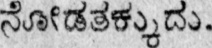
ನೋಡತಕ್ಕುದು.
